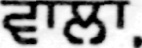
ਵਾਲਾ,
